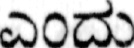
ಎಂದು
